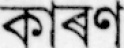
কাৰণ
